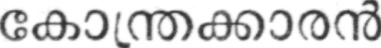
കോന്ത്രക്കാരന്‍
